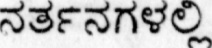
ನರ್ತನಗಳಲ್ಲಿ
